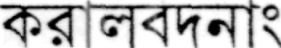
করালবদনাং
